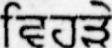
ਵਿਹੜੇ
